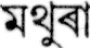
মথুৰা
